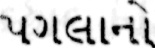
પગલાનો
